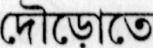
দৌড়োতে
